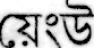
য়েংউ
